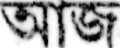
আজ
